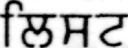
ਲਿਸਟ
